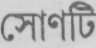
সোণটি
